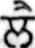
ਲੈ
